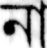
না
